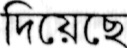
দিয়েছে
